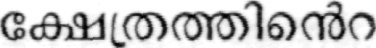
ക്ഷേത്രത്തിന്റെ
